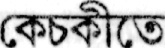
কেচকীতে
